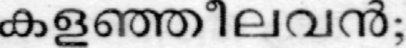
കളഞ്ഞീലവന്‍;
